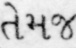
તેમજ
